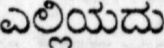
ಎಲ್ಲಿಯದು
